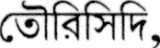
তৌরিসিদি,
